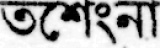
তশেংনা
